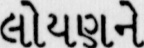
લોયણને
